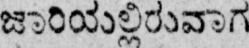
ಜಾರಿಯಲ್ಲಿರುವಾಗ
